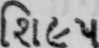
શિલ્પ
